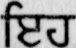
ਇਹ
